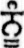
ਨੂੰ
